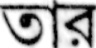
তার
